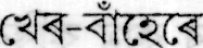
খেৰ-বাঁহেৰে
